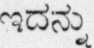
ಇದನ್ನು
